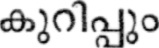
കുറിപ്പും
